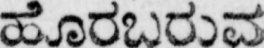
ಹೊರಬರುವ
